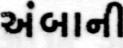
અંબાની
